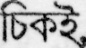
চিকই,
